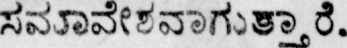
ಸಮಾವೇಶವಾಗುತ್ತಾರೆ.
